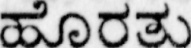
ಹೊರತು
